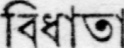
বিধাতা
